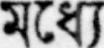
মধ্যে
